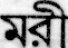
মরী
